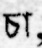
চা,
